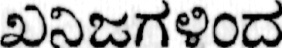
ಖನಿಜಗಳಿಂದ
